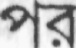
পর
